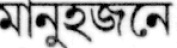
মানুহজনে
